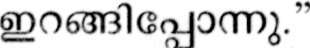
ഇറങ്ങിപ്പോന്നു.”
